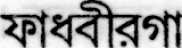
ফাধবীরগা
